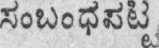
ಸಂಬಂಧಪಟ್ಟ
